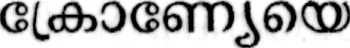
ക്രോണ്യേയെ
